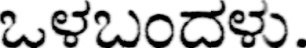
ಒಳಬಂದಳು.
